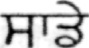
ਸਾਡੇ
